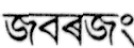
জবৰজং
